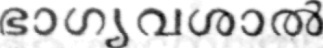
ഭാഗ്യവശാല്‍
